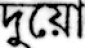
দুয়ো
